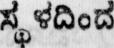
ಸ್ಥಳದಿಂದ
